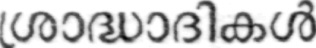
ശ്രാദ്ധാദികള്‍
